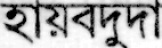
হায়বদুদা
